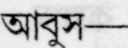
আবুস–
